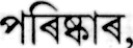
পৰিষ্কাৰ,
